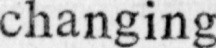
changing
